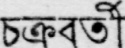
চক্রবর্তী
